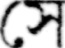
সে
